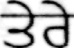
ਤੇਰੇ
